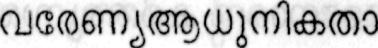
വരേണ്യആധുനികതാ
